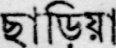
ছাড়িয়া
